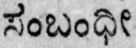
ಸಂಬಂಧೀ
